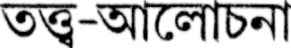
তত্ত্ব-আলোচনা
